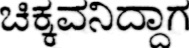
ಚಿಕ್ಕವನಿದ್ದಾಗ
